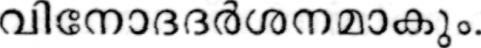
വിനോദദര്‍ശനമാകും.
